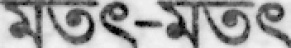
মতৎ-মতৎ
